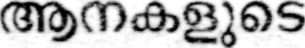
ആനകളുടെ
